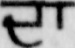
ਦਾ
